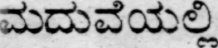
ಮದುವೆಯಲ್ಲಿ
